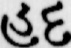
હદ
